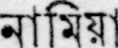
নামিয়া
